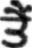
ਤੈਂ
